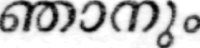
ഞാനും
